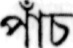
পাঁচ
